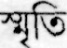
স্মৃতি
